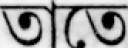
তাতে
